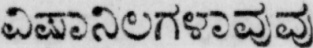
ವಿಷಾನಿಲಗಳಾವುವು
